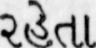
રહેતા
